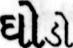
ઘોડો
